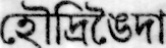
হৌদ্রিঙৈদা
